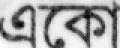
একো
